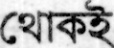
থোকই
